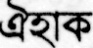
ঐহাক
